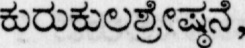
ಕುರುಕುಲಶ್ರೇಷ್ಠನೆ,
